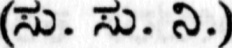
(ಸು.ಸು.ನಿ.)
